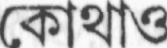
কোথাও
